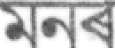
মনৰ
